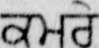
ਕਮਰੇ
